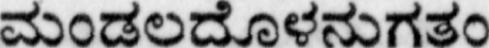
ಮಂಡಲದೊಳನುಗತಂ
